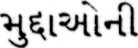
મુદ્દાઓની
